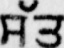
ਸੱਤ
